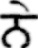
ਨੇ
